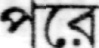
পরে
